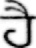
ਹੈ
